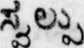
ಸ್ವಲ್ಪು
